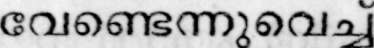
വേണ്ടെന്നുവെച്ച്
